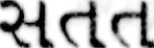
સતત
